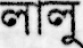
লালু
